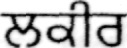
ਲਕੀਰ
